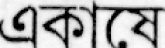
একাষে
